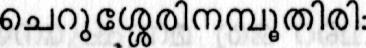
ചെറുശ്ശേരിനമ്പൂതിരി:
